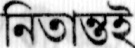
নিতান্তই
